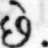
છે.
